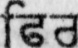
ਫਿਰ
